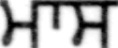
ਮਾਸ
